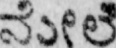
ಮೇಲೆ
